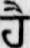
ਹੈ
